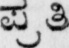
ಪ್ರತಿ
